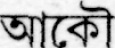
আকৌ
